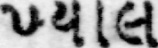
ખ્યાલ
